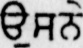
ਉਸਨੇ
